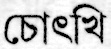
চোৎখি
